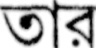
তার
